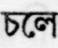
চলে
